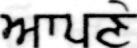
ਆਪਣੇ
